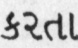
કરતા
